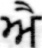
ਐ
